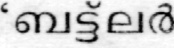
‘ബട്ട്ലര്‍
